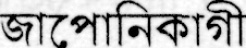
জাপোনিকাগী
